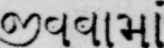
જીવવામાં
